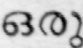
ഒരു
